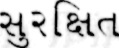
સુરક્ષિત
